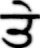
ਤੇ
